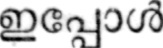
ഇപ്പോള്‍
